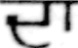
ਦਾ
